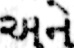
અને
